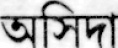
অসিদা
